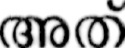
അത്
